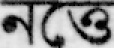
নত্তে
